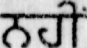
ਨਹੀਂ
